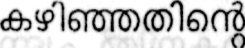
കഴിഞ്ഞതിന്റെ
